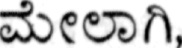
ಮೇಲಾಗಿ,
